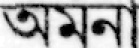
অমনা
